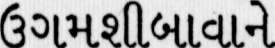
ઉગમશીબાવાને
